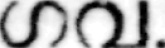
ഗവ.
